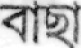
বাছা
